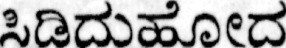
ಸಿಡಿದುಹೋದ
